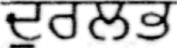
ਦੁਰਲਭ
